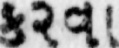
કરવા
